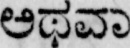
ಅಥವಾ
